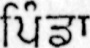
ਪਿੰਡਾ
